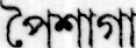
পৈশাগা
